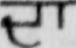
ਦਾ
